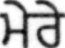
ਮੇਰੇ
